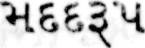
મદદરૂપ
